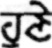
ਹੁਣੇ
